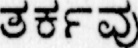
ತರ್ಕವು
